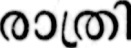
രാത്രി
